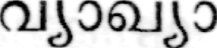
വ്യാഖ്യാ
